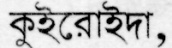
কুইরোইদা,
